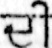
ਦੀ
